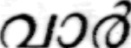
വാര്‍
